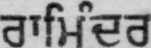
ਰਾਮਿੰਦਰ
